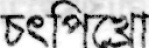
চৎপিখ্রো
